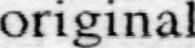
original
